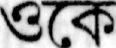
ওকে
